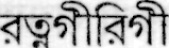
রত্নগীরিগী
